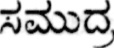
ಸಮುದ್ರ
